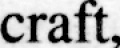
craft,
